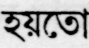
হয়তো
